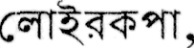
লোইরকপা,
